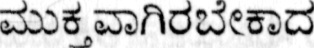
ಮುಕ್ತವಾಗಿರಬೇಕಾದ
